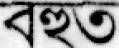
বহুত
